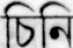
চিনি
